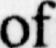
of
